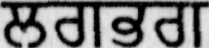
ਲਗਭਗ
